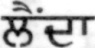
ਲੈਂਦਾ
